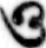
ও
